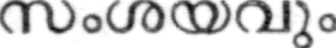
സംശയവും
